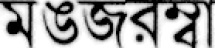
মঙজরম্বা
